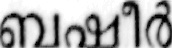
ബഷീര്‍
